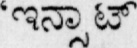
‘ಇನ್ಸಾಟ್
